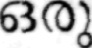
ഒരു
